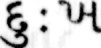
દુઃખ
